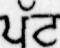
ਪੱਟ
